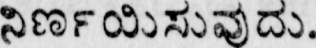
ನಿರ್ಣಯಿಸುವುದು.
